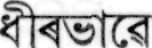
ধীৰভাৱে
